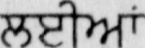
ਲਈਆਂ
